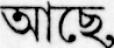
আছে,
